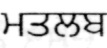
ਮਤਲਬ
